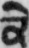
ਕੇ
